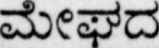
ಮೇಘದ
